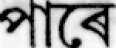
পাৰে
